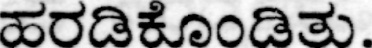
ಹರಡಿಕೊಂಡಿತು.
